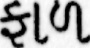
ફાળ
